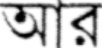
আর
